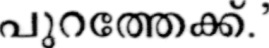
പുറത്തേക്ക്.’
